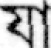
যা
